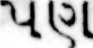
પણ
